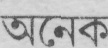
অনেক
